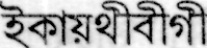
ইকায়থীবীগী
